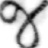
જ
